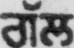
ਗੱਲ
